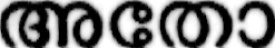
അതോ
